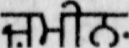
ਜ਼ਮੀਨ
